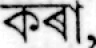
কৰা,
